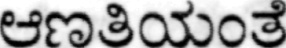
ಆಣತಿಯಂತೆ
